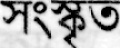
সংস্কৃত
